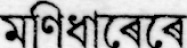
মণিধাৰেৰে
